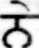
ਨੇ
